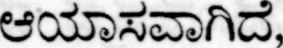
ಆಯಾಸವಾಗಿದೆ,
